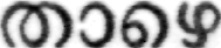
താഴെ
